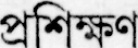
প্রশিক্ষণ
